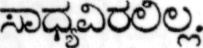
ಸಾಧ್ಯವಿರಲಿಲ್ಲ.
